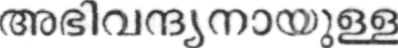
അഭിവന്ദ്യനായുള്ള
